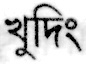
খুদিং
